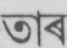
তাৰ
